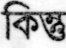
কিন্তু
